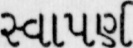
સ્વાપર્ણ
